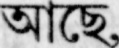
আছে,
